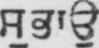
ਸੁਭਾਉ
